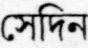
সেদিন
